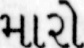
મારો
